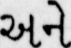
અને
